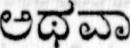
ಅಥವಾ
